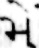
મેં
